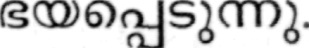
ഭയപ്പെടുന്നു.
